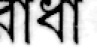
রাধা
